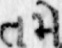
તમે
